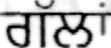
ਗੱਲਾਂ
